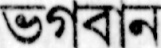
ভগবান
